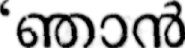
‘ഞാന്‍
